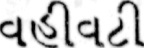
વહીવટી
